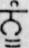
ਨੂੰ
